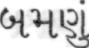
બમણું
